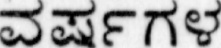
ವರ್ಷಗಳ
